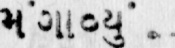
મંગાવ્યું.
